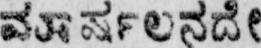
ಮಾರ್ಷಲನದೇ
